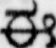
ಈ
